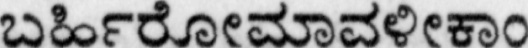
ಬರ್ಹಿರೋಮಾವಳೀಕಾಂ
